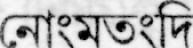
নোংমতংদি
